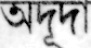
অদূদা
